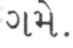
ગમે.
